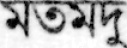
মতমদু
